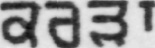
ਕਰੜਾ
